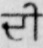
ਦੀ
